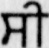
ਸੀ
